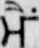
ਮੈਂ
